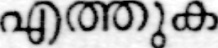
എത്തുക
